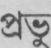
প্ৰভু
